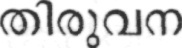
തിരുവന
